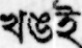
খঙই
